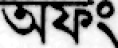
অফং
